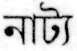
নাট্য
